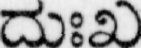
ದುಃಖ
